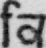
ਕਿ
